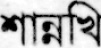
শান্নখি
